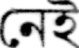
নেই
